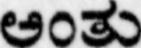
ಅಂತು
